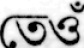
তেওঁ
